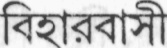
বিহারবাসী
